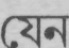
যেন
